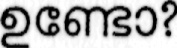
ഉണ്ടോ?
